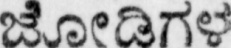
ಜೋಡಿಗಳ
